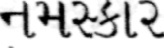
નમસ્કાર
